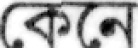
কেনে
